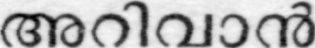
അറിവാന്‍
